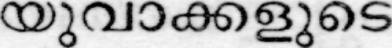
യുവാക്കളുടെ
